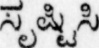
ಸೃಷ್ಟಿಸಿ
